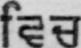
ਵਿਚ
